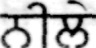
ਨੀਲੇ
